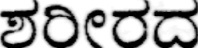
ಶರೀರದ
